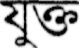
যুক্ত
